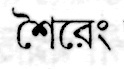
শৈরেং
